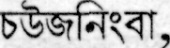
চাউজনিংবা,
